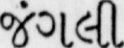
જંગલી
